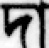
দা
